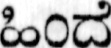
ಹಿಂದೆ
